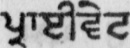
ਪ੍ਰਾਈਵੇਟ
